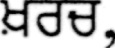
ਖ਼ਰਚ,
